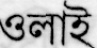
ওলাই
